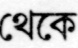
থেকে
